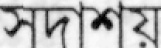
সদাশয়
